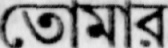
তোমার
